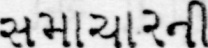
સમાચારની
